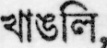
খাঙলি,
